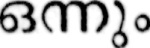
ഒന്നും
